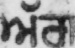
ਅੱਗ
